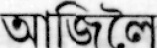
আজিলৈ
